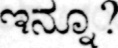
ಇನ್ನೂ?
